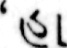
'હા
